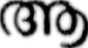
ആ
